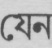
যেন
